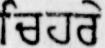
ਚਿਹਰੇ
